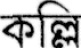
কল্লি
